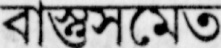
বাস্তুসমেত
